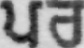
ਪਰ
